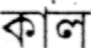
কাল
